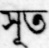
সূত
